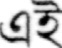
এই
